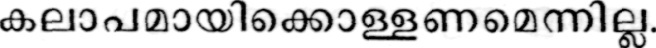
കലാപമായിക്കൊള്ളണമെന്നില്ല.
